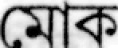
মোক
